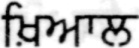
ਖ਼ਿਆਲ
